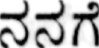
ನನಗೆ
